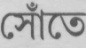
সোঁতে
